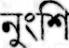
নুংশি
